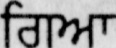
ਗਿਆ
